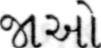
જાઓ
